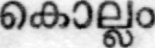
കൊല്ലം
